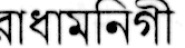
রাধামনিগী
